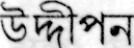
পদ্দীপন
